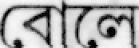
বোলে
